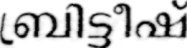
ബ്രിട്ടീഷ്
